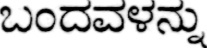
ಬಂದವಳನ್ನು
